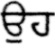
ਉਹ
